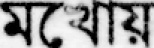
মখোয়
